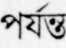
পর্যন্ত
